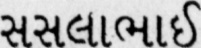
સસલાભાઈ
